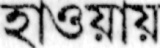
হাওয়ায়
